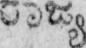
ರಾಜ್ಯ
